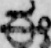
ಈ
